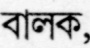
বালক,
